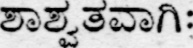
ಶಾಶ್ವತವಾಗಿ:
